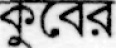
কুবের
